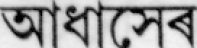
আধাসেৰ
